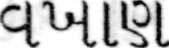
વખાણ
